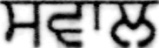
ਸਵਾਲ
